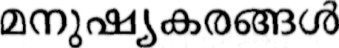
മനുഷ്യകരങ്ങള്‍
